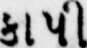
કાપી
